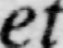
et
